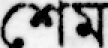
শেম
